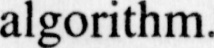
algorithm.
